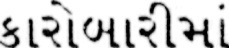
કારોબારીમાં
